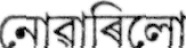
নোৱাৰিলো
